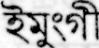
ইমুংগী
